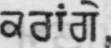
ਕਰਾਂਗੇ,
